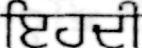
ਇਹਦੀ
